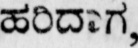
ಹರಿದಾಗ,
